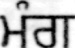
ਮੰਗ
